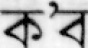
ক'ব
